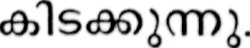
കിടക്കുന്നു.
